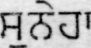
ਸੁਨੇਹਾ
